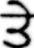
ਤੇ
